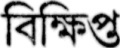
বিক্ষিপ্ত
